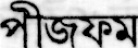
পীজফম
